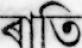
ৰাতি
